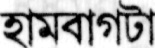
হামবাগটা
